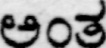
ಅ೦ತ
